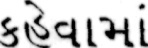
કહેવામાં
